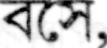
বসে,
